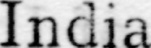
India
